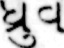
ધ્રુવ
